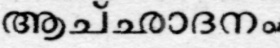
ആച്ഛാദനം
